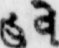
હવે
